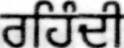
ਰਹਿੰਦੀ
